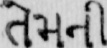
તેમની
